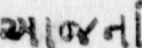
આજનાં
